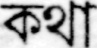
কথা
